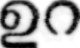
ഉറ
